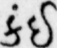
કંઈ
